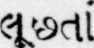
લૂછતાં
